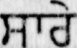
ਸਾਰੇ
